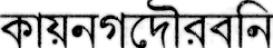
কায়নগদৌরবনি
